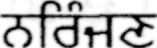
ਨਰਿੰਜਣ
